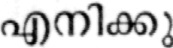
എനിക്കു
